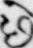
છે
